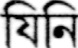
যিনি
